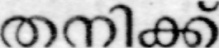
തനിക്ക്
